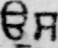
ਉਸ
